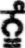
ਨੂੰ
